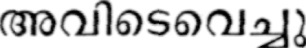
അവിടെവെച്ചു
